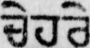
ਚੇਹਰੇ
